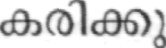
കരിക്കു
